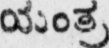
ಯಂತ್ರ
